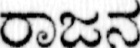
ರಾಜನ
